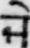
ਜੇ
